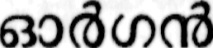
ഓര്‍ഗന്‍
